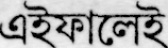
এইফালেই
